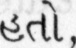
હતો,
